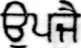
ਉਪਜੈ
